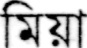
মিয়া
